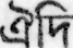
ঐদি
